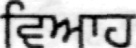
ਵਿਆਹ
